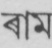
ৰাম
